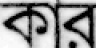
কার
